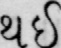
થઈ
